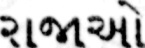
રાજાઓ
